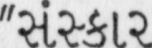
"સંસ્કાર
